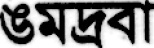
ঙমদ্রবা
